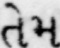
તેમ
